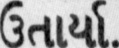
ઉતાર્યા.
